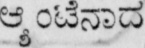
ಆಂಟೆನಾದ
